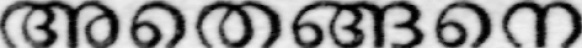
അതെങ്ങനെ
